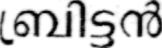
ബ്രിട്ടന്‍
